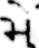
મેં
